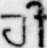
ਹੀ
